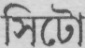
সিটো
